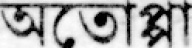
অতোপ্পা
